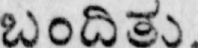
ಬಂದಿತು.
